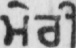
ਮੇਰੀ
